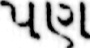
પણ
